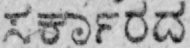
ಸರ್ಕಾರದ
